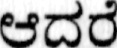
ಆದರೆ
